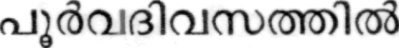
പൂര്‍വദിവസത്തില്‍
